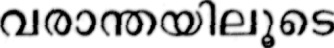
വരാന്തയിലൂടെ
